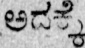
ಅದಕ್ಕೆ
